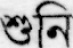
শুনি
